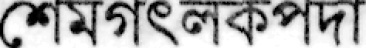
শেমগৎলকপদা
